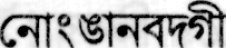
নোংঙানবদগী
